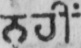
ਨਹੀਂ
